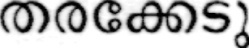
തരക്കേടു
